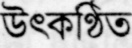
উত্কণ্ঠিত
